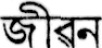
জীৱন
